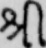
શ્રી
